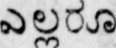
ಎಲ್ಲರೂ
